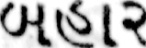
બહાર
